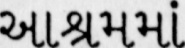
આશ્રમમાં
